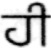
ਹੀ
